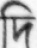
দি
